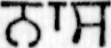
ਨਾਸ
